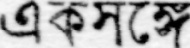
একসঙ্গে
